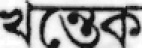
খন্তেক
